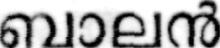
ബാലന്‍
